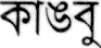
কাঙবু
